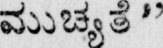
ಮುಚ್ಯತೆ”
